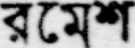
রমেশ
